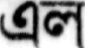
এল
